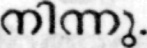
നിന്നു.
